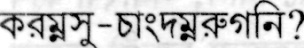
করম্নসু-চাংদম্নরুগনি?
